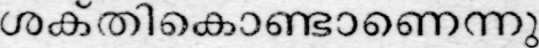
ശക്തികൊണ്ടാണെന്നു
